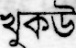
খুকউ
